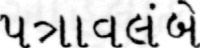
પત્રાવલંબે
